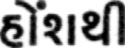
હોંશથી
